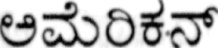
ಅಮೆರಿಕನ್
